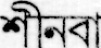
শীনবা
